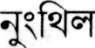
নুংথিল
